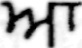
ਆ
